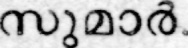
സുമാര്‍.
